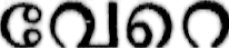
വേറെ
